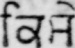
ਕਿਸੇ
